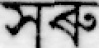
সৰু
